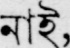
নাই,
